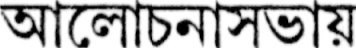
আলোচনাসভায়
